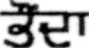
ਭੌਂਦਾ
